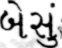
બેસું
